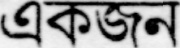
একজন
